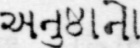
અનુષ્ટાનો
